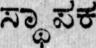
ಸ್ಥಾಪಕ
